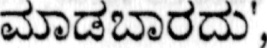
ಮಾಡಬಾರದು’,
